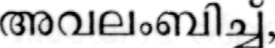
അവലംബിച്ച്,
